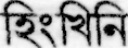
হিংখিনি
